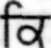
ਕਿ
